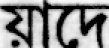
য়াদে
